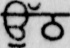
ਉੱਠ
